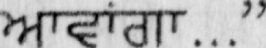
ਆਵਾਂਗਾ....''
